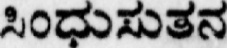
ಸಿಂಧುಸುತನ
